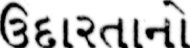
ઉદારતાનો
